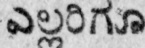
ಎಲ್ಲರಿಗೂ
